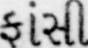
ફાંસી
